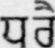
ਧਰੈ
